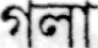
গলা
